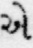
એ
